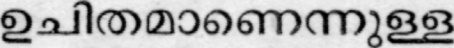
ഉചിതമാണെന്നുള്ള
